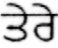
ਤੇਰੇ
